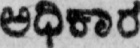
ಅಧಿಕಾರ
